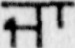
ਜਾ
